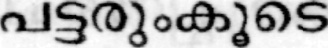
പട്ടരുംകൂടെ
